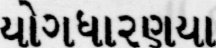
યોદધારણયા
